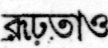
রূঢ়তাও
